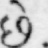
છે.
